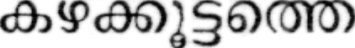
കഴക്കൂട്ടത്തെ
